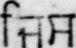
ਜਿਸ
